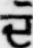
ਦੋ
